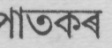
পাতকৰ
